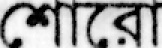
শোরো
